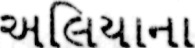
અલિયાના
